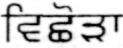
ਵਿਛੋੜਾ
